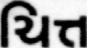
ચિત્ત
